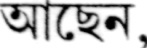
আছেন,
